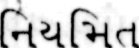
નિયમિત
